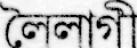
লৈলাগী
